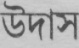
উদাস
